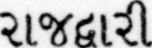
રાજદ્વારી
